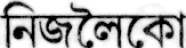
নিজলৈকো
